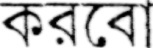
করবো
